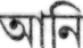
আনি
